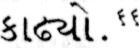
કાઢ્યો.૬૬
